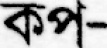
কপ-
